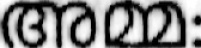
അമ്മ:
